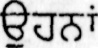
ਉਹਨਾਂ
